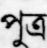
পুত্র
